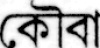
কৌবা
